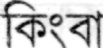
কিংবা
